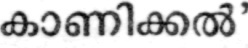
കാണിക്കല്‍’
